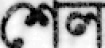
শেল
